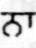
ਨਾ
